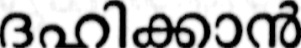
ദഹിക്കാന്‍
